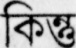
কিন্তু
